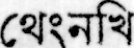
থেংনখি
